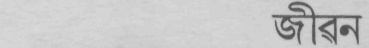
জীৱন
